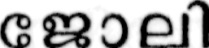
ജോലി
